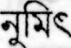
নুমিৎ
